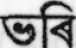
ভৰি
